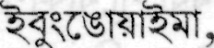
ইবুংঙোয়াইমা,
